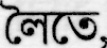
লৈতে,
